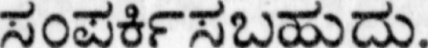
ಸಂಪರ್ಕಿಸಬಹುದು.
